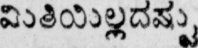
ಮಿತಿಯಿಲ್ಲದಷ್ಟು
